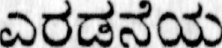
ಎರಡನೆಯ
